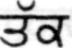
ਤੱਕ
